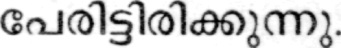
പേരിട്ടിരിക്കുന്നു.
